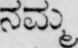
ನಮ್ಮ
